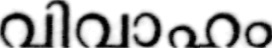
വിവാഹം
